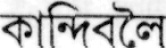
কান্দিবলৈ
